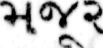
મજૂર
